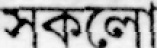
সকলো
